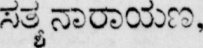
ಸತ್ಯನಾರಾಯಣ,
